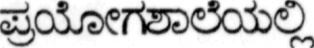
ಪ್ರಯೋಗಶಾಲೆಯಲ್ಲಿ
